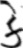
કે
